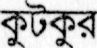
কুটকুর
